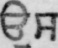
ਉਸ
